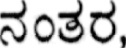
ನಂತರ,
